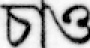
চাও
